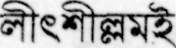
লীৎশীল্লমই
